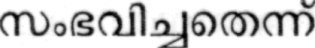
സംഭവിച്ചതെന്ന്
